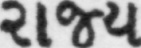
રાજ્ય
